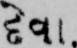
દેવા.
